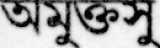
অমুক্তসু
